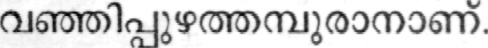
വഞ്ഞിപ്പുഴത്തമ്പുരാനാണ്.
